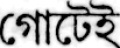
গোটেই
